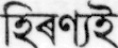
হিৰণ্যই
